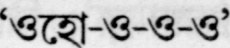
‘ওহো-ও-ও-ও’
